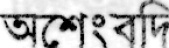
অশেংবদি
